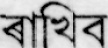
ৰাখিব
